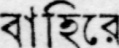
বাহিরে
